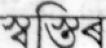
স্বস্তিৰ
